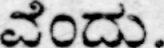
ವೆಂದು.
